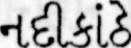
નદીકાંઠે
